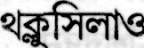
থক্লুসিলাও
